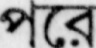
পরে
